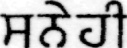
ਸਨੇਹੀ
